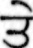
ਤੇ
